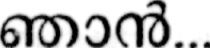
ഞാന്‍...
